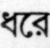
ধরে
